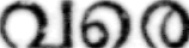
വരെ
